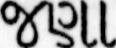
જણા
